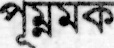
পূম্নমক
